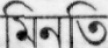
মিনতি
